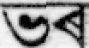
ভৰ
